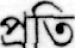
প্রতি
